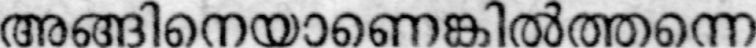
അങ്ങിനെയാണെങ്കില്‍ത്തന്നെ
